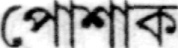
পোশাক
